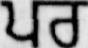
ਪਰ
